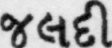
જલદી
